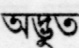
অদ্ভুত
